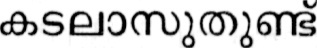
കടലാസുതുണ്ട്
